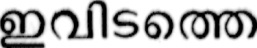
ഇവിടത്തെ
